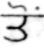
ਤੋਂ
